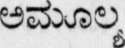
ಅಮೂಲ್ಯ
